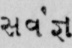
સર્વજ્ઞ
